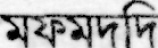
মফমদদি
